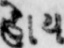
હોય
